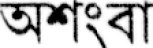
অশংবা
